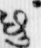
છું
